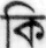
কি
